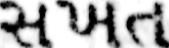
સખત
